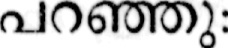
പറഞ്ഞു:
